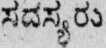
ಸದಸ್ಯರು
